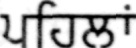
ਪਹਿਲਾਂ
